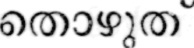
തൊഴുത്
